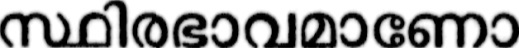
സ്ഥിരഭാവമാണോ
